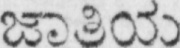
ಜಾತಿಯ
